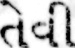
તેવી
